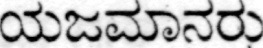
ಯಜಮಾನರು
